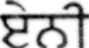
ਏਨੀ
